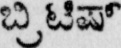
ಬ್ರಿಟಿಷ್
